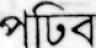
পঢ়িব
